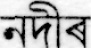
নদীৰ
